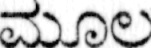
ಮೂಲ
